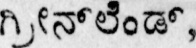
ಗ್ರೀನ್ಲೆಂಡ್,
